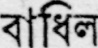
বাধিল
